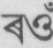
ৰওঁ
